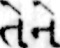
તેને
